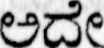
ಅದೇ
